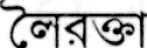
লৈরক্তা
